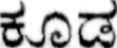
ಕೂಡ
